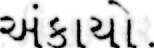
અંકાયો.
